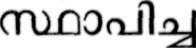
സ്ഥാപിച്ച
